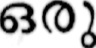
ഒരു
